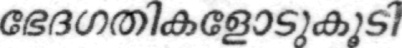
ഭേദഗതികളോടുകൂടി
